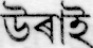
উৰাই
